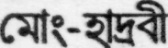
মোং-হাদ্রবী
